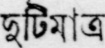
দুটিমাত্র
